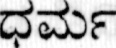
ಧರ್ಮ
